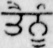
ਤੈਨੂੰ
